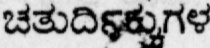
ಚತುರ್ದಿಕ್ಕುಗಳ
